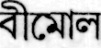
বীমোল
